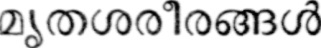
മൃതശരീരങ്ങള്‍
